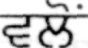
ਵਲੋਂ
